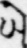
બે
